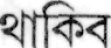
থাকিব
